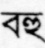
বহু
